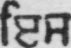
ਇਸ
